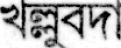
খল্লুবদা
